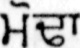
ਮੋਢਾ
